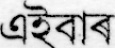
এইবাৰ
